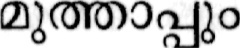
മുത്താപ്പും
